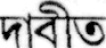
দাবীত
